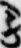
કે
